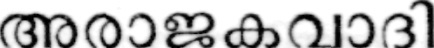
അരാജകവാദി
